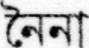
নৈনা
